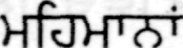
ਮਹਿਮਾਨਾਂ
